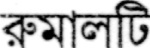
রুমালটি
